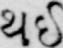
થઈ
